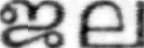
ജല
